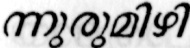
ന്നുരുമിഴി
